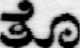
ತೊ
